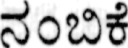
ನಂಬಿಕೆ
